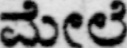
ಮೇಲೆ
